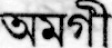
অমগী
